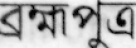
ব্রহ্মপুত্র
